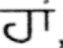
ਹਾਂ,
